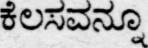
ಕೆಲಸವನ್ನೂ
